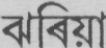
ঝৰিয়া
